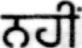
ਨਹੀਂ
